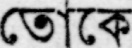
তোকে
